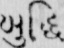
બુદ્ધિ
